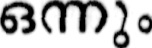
ഒന്നും
